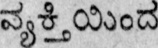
ವ್ಯಕ್ತಿಯಿಂದ
